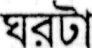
ঘরটা
